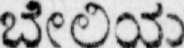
ಬೇಲಿಯ
